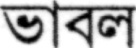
ভাবল
